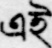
এই
